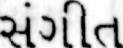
સંગીત
